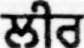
ਲੀਰ
